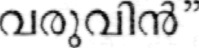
വരുവിന്‍”
